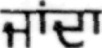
ਜਾਂਦਾ
